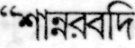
“শান্নরবদি
